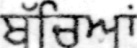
ਬੱਚਿਆਂ
